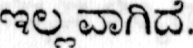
ಇಲ್ಲವಾಗಿದೆ.
